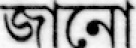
জানো
